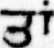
ਤਾਂ
